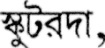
স্কুটরদা,
